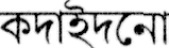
কদাইদনো
